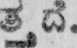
ತ್ತದೆ.
